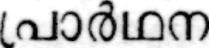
പ്രാര്‍ഥന
